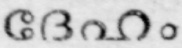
ദേഹം
